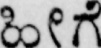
ಹೀಗೆ
